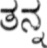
ತನ್ನ
